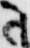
તે
